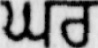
ਘਰ
